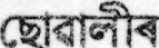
ছোৱালীৰ
